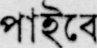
পাইবে
